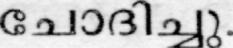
ചോദിച്ചു.
